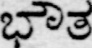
ಭೌತ
